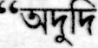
“অদুদি
